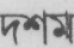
দশম
